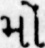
મોં
